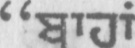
''ਬਾਹਾਂ
